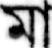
মা
